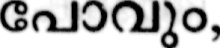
പോവും,
